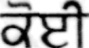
ਕੋਈ
